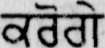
ਕਰੋਗੇ
